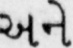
અને
